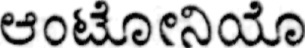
ಆಂಟೋನಿಯೊ
